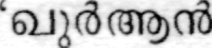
‘ഖുര്‍ആന്‍
